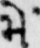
મેં
